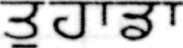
ਤੁਹਾਡਾ
